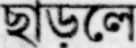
ছাড়লে
